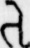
તે
